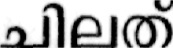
ചിലത്
